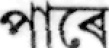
পাৰে
